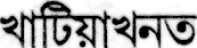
খাটিয়াখনত
